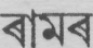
ৰামৰ
